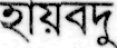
হায়বদু
